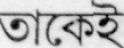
তাকেই
